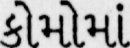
કોમોમાં
